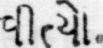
વીત્યો.
